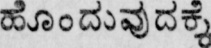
ಹೊಂದುವುದಕ್ಕೆ
